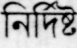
নির্দিষ্ট
